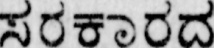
ಸರಕಾರದ
